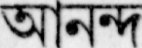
আনন্দ
